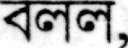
বলল,
